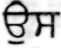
ਉਸ
